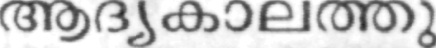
ആദ്യകാലത്തു
